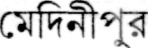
মেদিনীপুর
